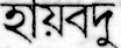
হায়বদু
